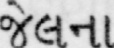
જેલના
